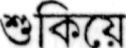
শুকিয়ে
